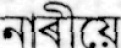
নাৰীয়ে
